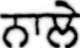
ਨਾਲੇ
